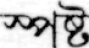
স্পষ্ট
